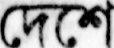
দেশে
